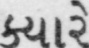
ક્યારે
